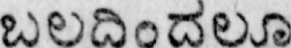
ಬಲದಿಂದಲೂ
